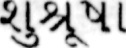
શુશ્રૂષા
